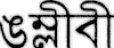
ঙম্লীবী
